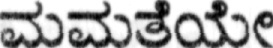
ಮಮತೆಯೇ
